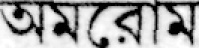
অমরোম
